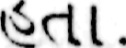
રાજકોટમાં
